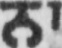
ਨਾ
